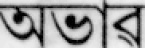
অভাৱ
